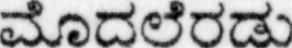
ಮೊದಲೆರಡು
